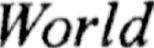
World
